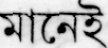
মানেই
